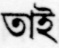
তাই
